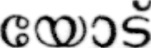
യോട്
